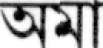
অমা
